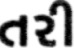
તરી
